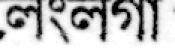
লেংলগা
